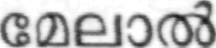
മേലാല്‍
